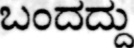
ಬಂದದ್ದು
